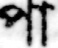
পা
